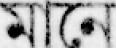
মানে
